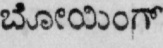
ಬೋಯಿಂಗ್
